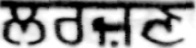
ਲਰਜ਼ਣ
